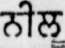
ਨੀਲੂ
